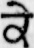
ਕੇ
